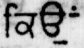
ਕਿਉਂ
